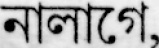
নালাগে,
